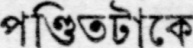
পণ্ডিতটাকে
